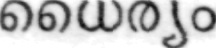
ധൈര്യം
